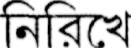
নিরিখে
